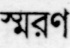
স্মরণ
